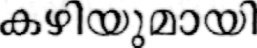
കഴിയുമായി
